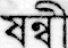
ষন্বী
